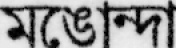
মঙোন্দা
